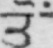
ਤੋਂ
